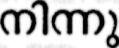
നിന്നു
